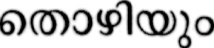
തൊഴിയും
